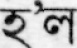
হ'ল
